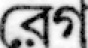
রেগ
